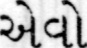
એવો
